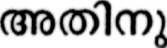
അതിനു
